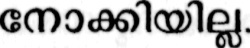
നോക്കിയില്ല.
